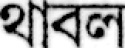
থাবল
